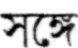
সঙ্গে
